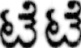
ಟೆಟೆ
